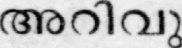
അറിവു
